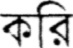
করি
